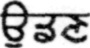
ਉਡਣ
